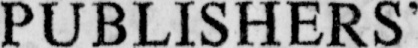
PUBLISHERS
